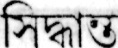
সিদ্ধান্ত
